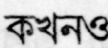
কখনও
